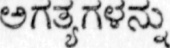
ಅಗತ್ಯಗಳನ್ನು
